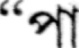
“পা
